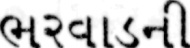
ભરવાડની
